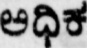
ಅಧಿಕ
